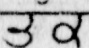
ਤੱਕ
